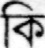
কি
